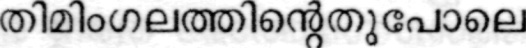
തിമിംഗലത്തിന്റെതുപോലെ
